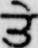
ਤੇ
